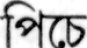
পিচে
